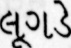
લૂગડે
